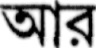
আর
